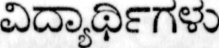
ವಿದ್ಯಾರ್ಥಿಗಳು
